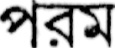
পরম
